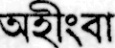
অহীংবা
